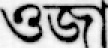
ওজা
